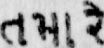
તમારે
